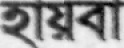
হায়বা
